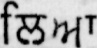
ਲਿਆ
